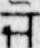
ਜੋ
